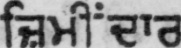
ਜ਼ਿਮੀਂਦਾਰ
